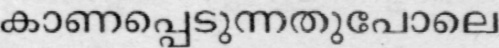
കാണപ്പെടുന്നതുപോലെ
